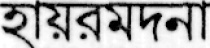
হায়রমদনা
